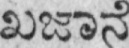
ಖಜಾನೆ
